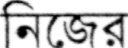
নিজের
